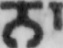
ਨਾ
